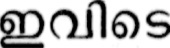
ഇവിടെ
